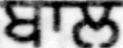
ਬਾਲ
